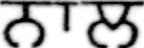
ਨਾਲ
